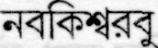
নবকিশ্বরবু
